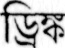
ড্রিঙ্ক
